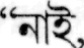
"নাই,
